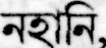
নহানি,
